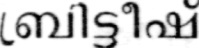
ബ്രിട്ടീഷ്
